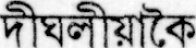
দীঘলীয়াকৈ
